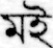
মই
